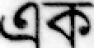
এক
